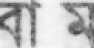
বা ম
